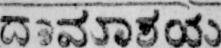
ದಾಮಾಶಯ
